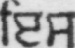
ਇਸ
